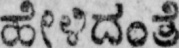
ಹೇಳಿದಂತೆ
